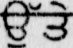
ਉੱਤੇ
